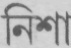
নিশা
